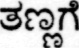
ತಣ್ಣಗೆ
